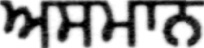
ਅਸਮਾਨ
